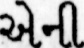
એની
